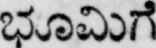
ಭೂಮಿಗೆ
